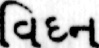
વિધ્ન
